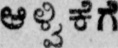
ಆಳ್ವಿಕೆಗೆ
